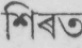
শিৰত
